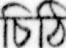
চিঠি
